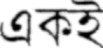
একই
